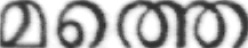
മത്തെ
